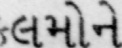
કલમોને
